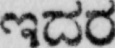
ಇದರ
